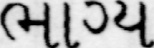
ભાગ્ય
